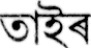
তাইৰ
